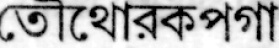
তৌথোরকপগা
